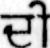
ਦੀ
